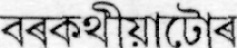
বৰকথীয়াটোৰ
